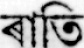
ৰাতি
